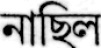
নাছিল
